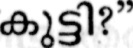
കുട്ടി?”
